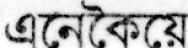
এনেকৈয়ে
